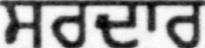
ਸਰਦਾਰ
